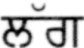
ਲੱਗ
